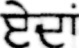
ਏਦਾਂ
